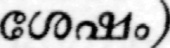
ശേഷം)
